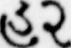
હર
